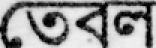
তেবল
